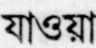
যাওয়া
